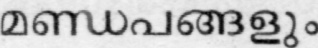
മണ്ഡപങ്ങളും
